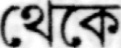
থেকে
